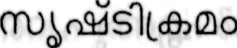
സൃഷ്ടിക്രമം
